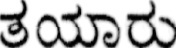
ತಯಾರು
